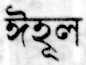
ঈহূল
